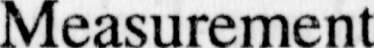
Measurement
